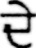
ਦੇ
